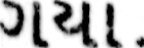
ગયા.
